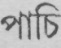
পাচি
